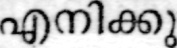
എനിക്കു
